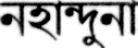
নহান্দুনা
